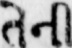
તેની
